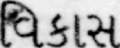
વિકાસ
